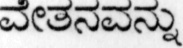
ವೇತನವನ್ನು
